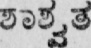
ಶಾಶ್ವತ
